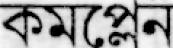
কমপ্লেন
